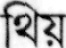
থিয়
